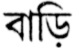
বাড়ি
